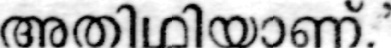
അതിഥിയാണ്.'
